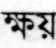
ক্ষয়
